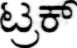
ಟ್ರಕ್
